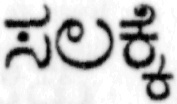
ಮೇಲಾಗಿ
